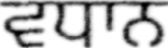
ਵਧਾਨ
